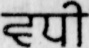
ਵਧੀ
